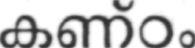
കണ്ഠം
